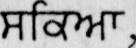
ਸਕਿਆ,
